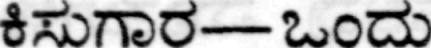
ಕಿಸುಗಾರ-ಒಂದು
